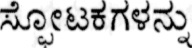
ಸ್ಫೋಟಕಗಳನ್ನು
